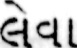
લેવા
